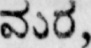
ಮರ,
